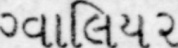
ગ્વાલિયર
